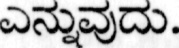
ಎನ್ನುವುದು.
